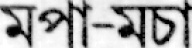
মপা-মচা
